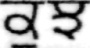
ਕੁਝ
